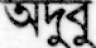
অদুবু
